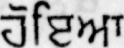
ਹੋਇਆ
